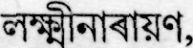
লক্ষ্মীনাৰায়ণ,
